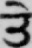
ਤੇ
